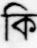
কি
